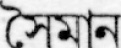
সৈমান
